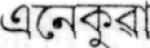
এনেকুৱা
